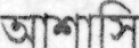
আশাসি
